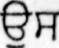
ਉਸ
